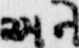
અને
